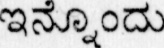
ಇನ್ನೊಂದು
